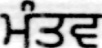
ਮੰਤਵ
